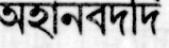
অহানবদদি
